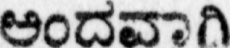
ಅಂದವಾಗಿ
